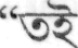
"তই
